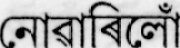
নোৱাৰিলোঁ
